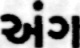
અંગ
